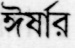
ঈর্ষার
